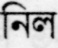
নিল
